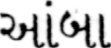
આંબા
